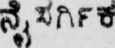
ನೈಸರ್ಗಿಕ
